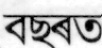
বছৰত
